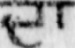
ਦਾ
